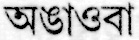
অঙাওবা
